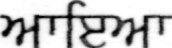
ਆਇਆ
